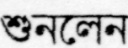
শুনলেন
